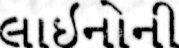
લાઇનોની
